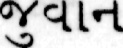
જુવાન
